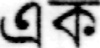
এক
